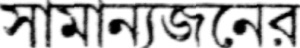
সামান্যজনের
